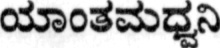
ಯಾಂತಮಧ್ವನಿ
